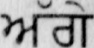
ਅੱਗੇ
